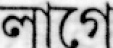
লাগে
